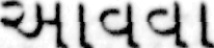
આવવા
